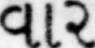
વાર
